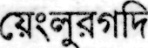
য়েংলুরগদি
